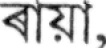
ৰায়া,
